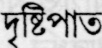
দৃষ্টিপাত
